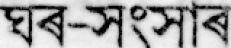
ঘৰ-সংসাৰ
